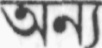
অন্য
